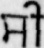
ਸੀ
